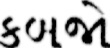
કબજો
